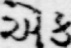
એક
